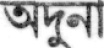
অদুনা
